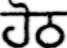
ਹੋਠ
